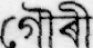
গৌৰী
